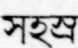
সহস্র
